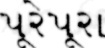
પૂરેપૂરા
